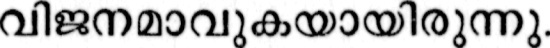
വിജനമാവുകയായിരുന്നു.
